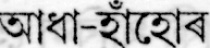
আধা-হাঁহোৰ
